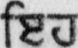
ਇਹ
